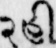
રહી
